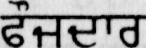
ਫੌਜਦਾਰ
